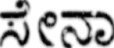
ಸೇನಾ
